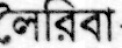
লৈরিবা
